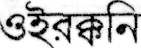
ওইরক্কনি
